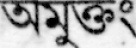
অমুক্তং
